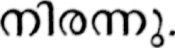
നിരന്നു.
